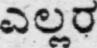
ಎಲ್ಲರ
